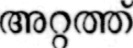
അറ്റത്ത്
